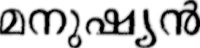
മനുഷ്യന്‍
